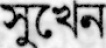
সুখেন
